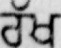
ਰੱਖ
